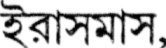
ইরাসমাস,
